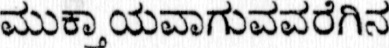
ಮುಕ್ತಾಯವಾಗುವವರೆಗಿನ
